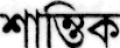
শান্তিক
